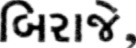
બિરાજે,
